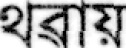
থৱায়
